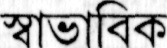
স্বাভাবিক
